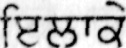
ਇਲਾਕੇ
